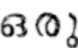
ഒരു
